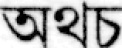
অথচ
